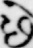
છે
